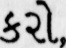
કરો,
